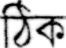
ঠিক
